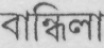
বান্ধিলা
